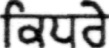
ਕਿਧਰੇ
